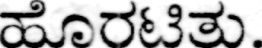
ಹೊರಟಿತು.
